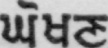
ਘੋਖਣ
